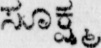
ಸೂಕ್ಷ್ಮ
